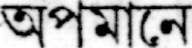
অপমানে
